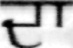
ਦਾ
